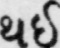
થઈ
